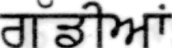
ਗੱਡੀਆਂ
